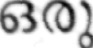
ഒരു
